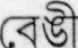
বেঙী
